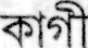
কাগী
